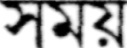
সময়
